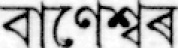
বাণেশ্বৰ
